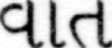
વાત
